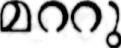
മററു
